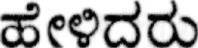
ಹೇಳಿದರು
